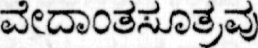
ವೇದಾಂತಸೂತ್ರವು
